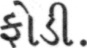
ફોડી.
